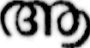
ആ
